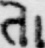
તો
